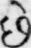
છે
